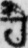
ਹੈ
